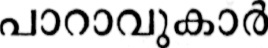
പാറാവുകാര്‍
